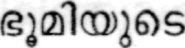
ഭൂമിയുടെ
